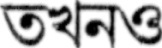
তখনও
